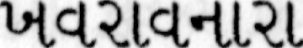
ખવરાવનારા
